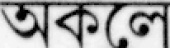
অকলে
